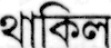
থাকিল
